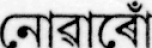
নোৱাৰোঁ
